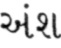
અંશ
